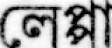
লেপ্পা
